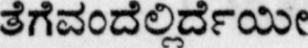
ತೆಗೆವಂದೆಲ್ಲಿರ್ದೆಯೀ
